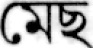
মেছ
